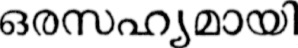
ഒരസഹ്യമായി
